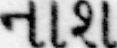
નાશ
